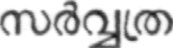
സര്‍വ്വത്ര
